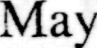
May
